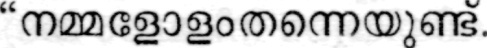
“നമ്മളോളംതന്നെയുണ്ട്.
